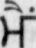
ਮੈਂ
